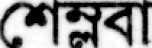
শেম্লবা
